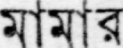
মামার
